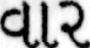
વાર
